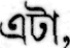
এটা,
